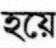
হয়ে
